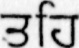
ਤਹਿ
